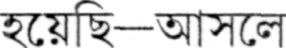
হয়েছি–আসলে
